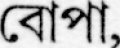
বোপা,
